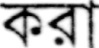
করা
